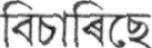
বিচাৰিছে
